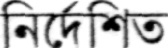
নির্দেশিত
